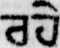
ਰਹੇ
